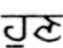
ਹੁਣ
